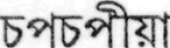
চপচপীয়া
